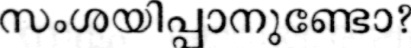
സംശയിപ്പാനുണ്ടോ?
